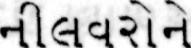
નીલવરોને
